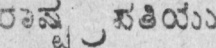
ರಾಷ್ಟ್ರಪತಿಯು
